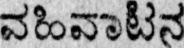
ವಹಿವಾಟಿನ
